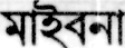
মাইবনা
